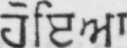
ਹੋਇਆ
